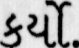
કર્યો.
